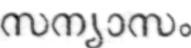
സന്യാസം
